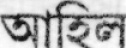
আহিল
